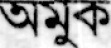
অমুক
